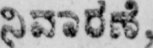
ನಿವಾರಣೆ,
